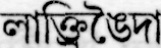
লাক্ত্রিঙৈদা
